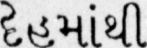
દેહમાંથી
